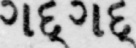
ગદૂગદ્
